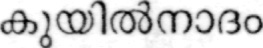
കുയില്‍നാദം
